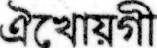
ঐখোয়গী
